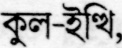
কুল-ইত্থি,
